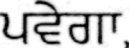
ਪਵੇਗਾ,
